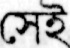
সেই
